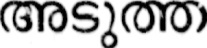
അടുത്ത
